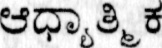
ಆಧ್ಯಾತ್ಮಿಕ
